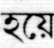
হয়ে
